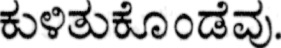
ಕುಳಿತುಕೊಂಡೆವು.
